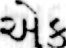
એક
